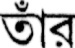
তাঁর
